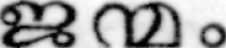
ജന്മം
